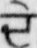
ਦੇ
